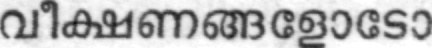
വീക്ഷണങ്ങളോടോ
